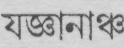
যজ্ঞানাঞ্চ
